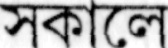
সকালে
